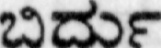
ಬಿರ್ದು
